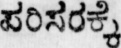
ಪರಿಸರಕ್ಕೆ
